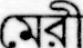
মেরী
